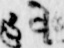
હવે
